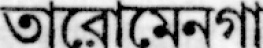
তারোমেনগা
